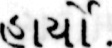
હાર્યો.
